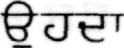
ਉਹਦਾ
